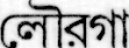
লৌরগা
